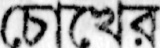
চোখের
